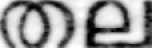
തല
